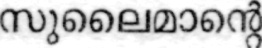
സുലൈമാന്റെ
